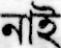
নাই
